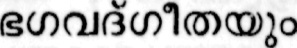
ഭഗവദ്ഗീതയും
